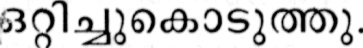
ഒറ്റിച്ചുകൊടുത്തു.
